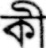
কী
